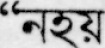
"নহয়
